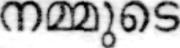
നമ്മുടെ
